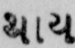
થાય
